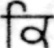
ਕਿ
